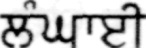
ਲੰਘਾਈ
